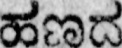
ಹಣದ
